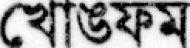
খোঙফম
